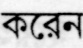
করেন
